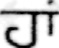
ਹਾਂ
